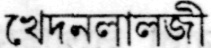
খেদনলালজী
